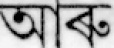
আৰু
